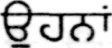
ਉਹਨਾਂ
